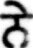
ਨੇ
